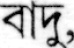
বাদু,
